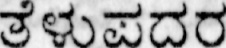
ತೆಳುಪದರ
